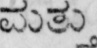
ಮತ್ತು
